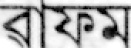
ৱাফম
